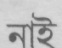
নাই
